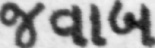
જવાબ
